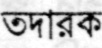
তদারক
